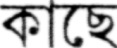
কাছে
